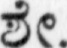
ಶೇ.
